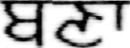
ਬਣਾ
